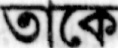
তাকে
